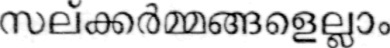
സല്ക്കര്‍മ്മങ്ങളെല്ലാം
